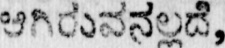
ಆಗಿರುವನಲ್ಲದೆ,
